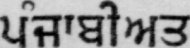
ਪੰਜਾਬੀਅਤ
